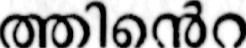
ത്തിന്റെ
